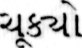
ચૂક્યો
